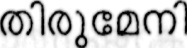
തിരുമേനി
